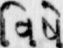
વિષે
